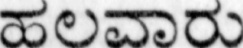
ಹಲವಾರು
